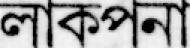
লাকপনা
